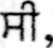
ਸੀ,
